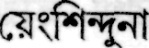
য়েংশিন্দুনা
